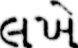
લખે
